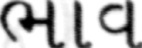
ભાવ
